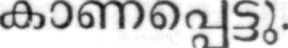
കാണപ്പെട്ടു.
